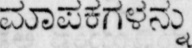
ಮಾಪಕಗಳನ್ನು
